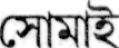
সোমাই
